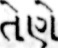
તેણે
